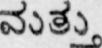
ಮತ್ತು
